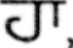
ਹਾਂ,
